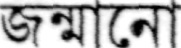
জন্মানো
